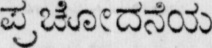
ಪ್ರಚೋದನೆಯ
